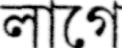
লাগে
